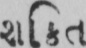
શક્તિ
